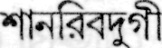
শানরিবদুগী
